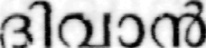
ദിവാന്‍
